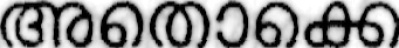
അതൊക്കെ
